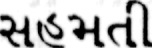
સહમતી
